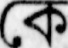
কে
